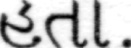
હતા.
